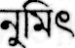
নুমিৎ
